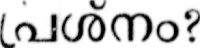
പ്രശ്നം?
